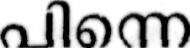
പിന്നെ
